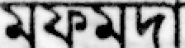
মফমদা
